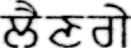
ਲੈਣਗੇ
